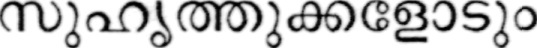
സുഹൃത്തുക്കളോടും
